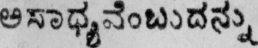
ಅಸಾಧ್ಯವೆಂಬುದನ್ನು
